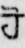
ਹੋ
